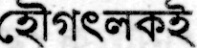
হৌগৎলকই
